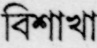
বিশাখা
